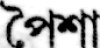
পৈশা
